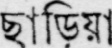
ছাড়িয়া
